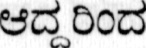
ಆದ್ದರಿಂದ
